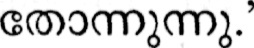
തോന്നുന്നു.’
